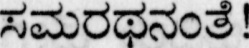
ಸಮರಥನಂತೆ!
